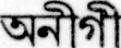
অনীগী
